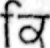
ਕਿ
